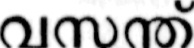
വസന്ത്
